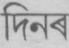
দিনৰ
